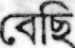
বেছি
